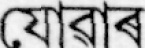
যোৱাৰ
